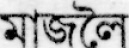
মাজলৈ
